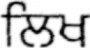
ਲਿਖ
